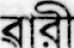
ৱারী
